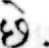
છે.
